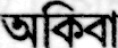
অকিবা
